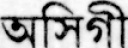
অসিগী
